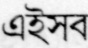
এইসব
